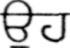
ਉਹ
